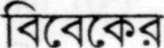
বিবেকের
